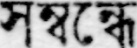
সম্বন্ধে
